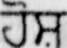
ਹੋਸ਼
